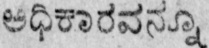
ಅಧಿಕಾರವನ್ನೂ
